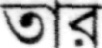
তার
